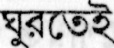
ঘুরতেই
